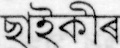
ছাইকীৰ
